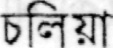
চলিয়া
